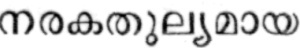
നരകതുല്യമായ
